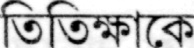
তিতিক্ষাকে
